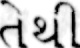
તેથી
